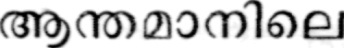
ആന്തമാനിലെ
